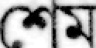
শেম
